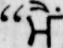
''ਮੈਂ
